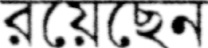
রয়েছেন
